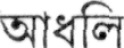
আধলি
